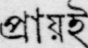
প্রায়ই
